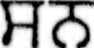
ਸਨ
